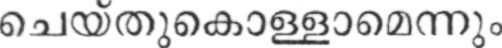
ചെയ്തുകൊള്ളാമെന്നും
